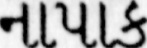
નાપાક
